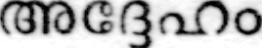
അദ്ദേഹം
